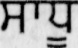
ਸਾਧੂ
